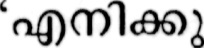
‘എനിക്കു
